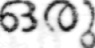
ഒരു
